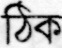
ঠিক
